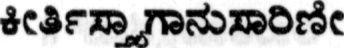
ಕೀರ್ತಿಸ್ತ್ಯಾಗಾನುಸಾರಿಣೀ
